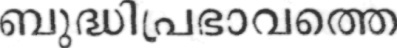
ബുദ്ധിപ്രഭാവത്തെ
